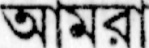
আমরা
